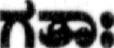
ಗತಾಃ
